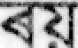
ৰয়
